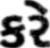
કરે
